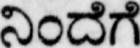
ನಿಂದೆಗೆ
